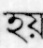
হয়
